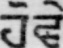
ਹੋਵੇ
